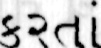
કરતાં
